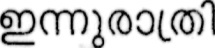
ഇന്നുരാത്രി
